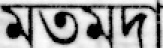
মতমদা
